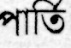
পার্তি
